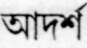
আদর্শ
